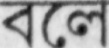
বলে
